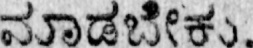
ಮಾಡಬೇಕು.
